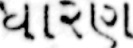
ધારણ
